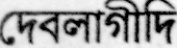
দেবলাগীদি
